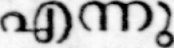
എന്നു
